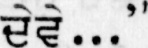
ਦੇਵੇ.......''
